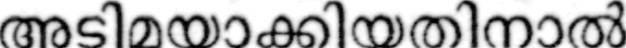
അടിമയാക്കിയതിനാല്‍
